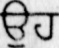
ਉਹ
